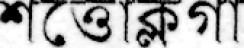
শত্তোক্লগা
